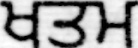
ਖਤਮ
